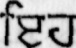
ਇਹ
